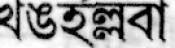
খঙহল্লবা
